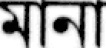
মানা
